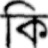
কি
